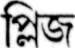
প্লিজ
